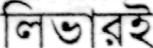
লিভারই
